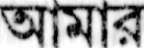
আমার
